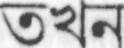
তখন
